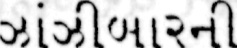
ઝાંઝીબારની
